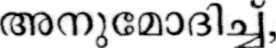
അനുമോദിച്ച്,
